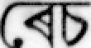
ৰেচ
